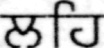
ਲਹਿ
